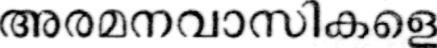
അരമനവാസികളെ
